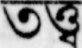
তত্ত্ব
